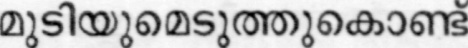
മുടിയുമെടുത്തുകൊണ്ട്
